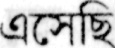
এসেছি
